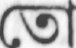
তো
